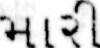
મારી
